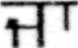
ਜਾ
